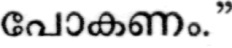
പോകണം.”
